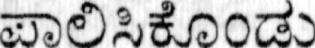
ಪಾಲಿಸಿಕೊಂಡು
